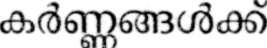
കര്‍ണ്ണങ്ങള്‍ക്ക്
